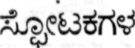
ಸ್ಫೋಟಕಗಳ
